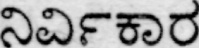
ನಿರ್ವಿಕಾರ
